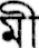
মী
